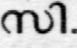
സി.
